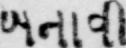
બનાવી
